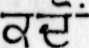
ਕਦੋਂ
